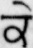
ਕੇ
